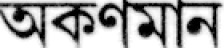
অকণমান
